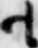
ન
